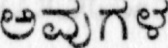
ಅವುಗಳ
